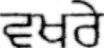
ਵਖਰੇ
